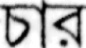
চার
